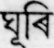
ঘূৰি
